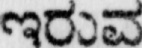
ಇರುವ
